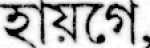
হায়গে,
